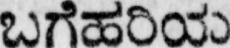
ಬಗೆಹರಿಯ
